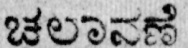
ಚಲಾವಣೆ
